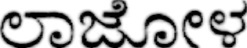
ಲಾಜೋಳ
